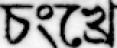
চংখ্রে
